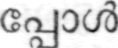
പ്പോള്‍
